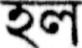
হল
